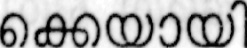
ക്കെയായി
